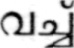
വച്ച്
